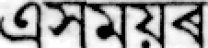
এসময়ৰ
